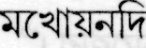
মখোয়নদি
